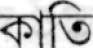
কাতি
